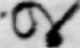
જ
